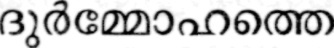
ദുര്‍മ്മോഹത്തെ
